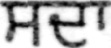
ਸਦਾ
